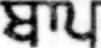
ਬਾਪ
